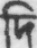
দি
